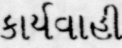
કાર્યવાહી
